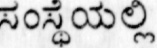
ಸಂಸ್ಥೆಯಲ್ಲಿ
